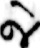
જે
